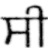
ਸੀ
